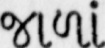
જાળાં
